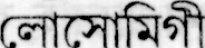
লোসোমিগী
